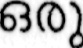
ഒരു
